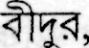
বীদুর,
